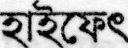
হাইফেৎ
